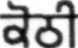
ਕੋਠੀ
